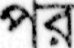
পর
